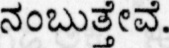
ನಂಬುತ್ತೇವೆ.
